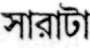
সারাটা
